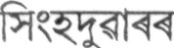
সিংহদুৱাৰৰ
